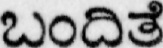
ಬಂದಿತೆ
